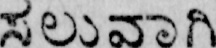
ಸಲುವಾಗಿ
